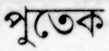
পুতেক
